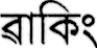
ৱাকিং
